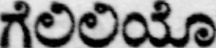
ಗೆಲಿಲಿಯೊ
